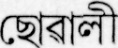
ছোৱালী
